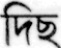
দিছ
